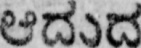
ಆದುದ
